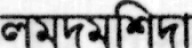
লমদমশিদা
